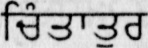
ਚਿੰਤਾਤੁਰ
